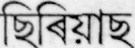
ছিৰিয়াছ
